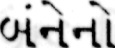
બંનેનો
